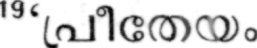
19'പ്രീതേയം
